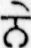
ਨੇ
